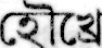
হৌখ্রে
